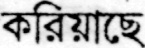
করিয়াছে
